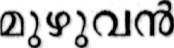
മുഴുവന്‍
